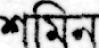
শমিন
